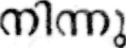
നിന്നു
